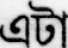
এটা
